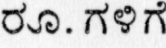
ರೂ.ಗಳಿಗೆ
